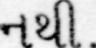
નથી.
